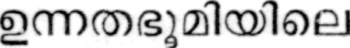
ഉന്നതഭൂമിയിലെ
